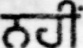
ਨਹੀਂ
